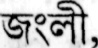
জংলী,
